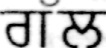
ਗੱਲ
